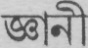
জ্ঞানী
